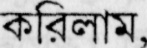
করিলাম,
